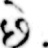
છે.
